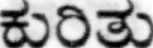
ಕುರಿತು
